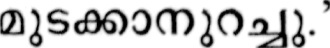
മുടക്കാനുറച്ചു.’
